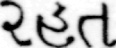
રહત
